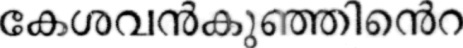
കേശവന്‍കുഞ്ഞിന്റെ
